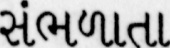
સંભળાતા
